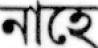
নাহে
